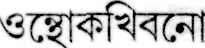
ওন্থোকখিবনো
